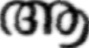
ആ
